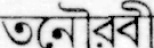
তনৌরবী
